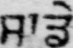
ਸਾਡੇ
